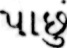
પાછું
